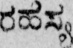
ರಹಸ್ಯ
